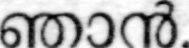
ഞാന്‍.
